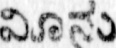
ಮೀನು
